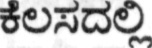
ಕೆಲಸದಲ್ಲಿ
